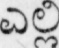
ಎಲ್ಲಿ
